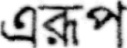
এরূপ
